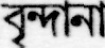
বৃন্দানা
